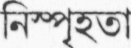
নিস্পৃহতা
